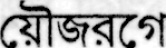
য়ৌজরগে
